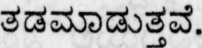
ತಡಮಾಡುತ್ತವೆ.
